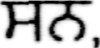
ਸਨ,
